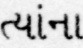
ત્યાંના
